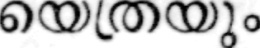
യെത്രയും
